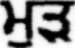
ਮੁੜ
